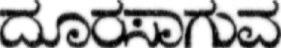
ದೂರಸಾಗುವ
